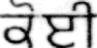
ਕੋਈ
